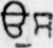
ਉਸ
